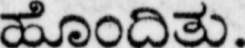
ಹೊಂದಿತು.
